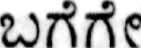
ಬಗೆಗೇ
